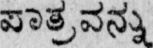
ಪಾತ್ರವನ್ನು
